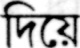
দিয়ে
